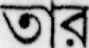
তার
